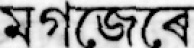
মগজেৰে
